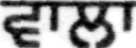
ਵਾਲਾ
